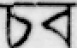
চব
